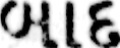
બાદ
